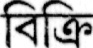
বিক্রি
